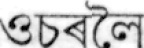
ওচৰলৈ
